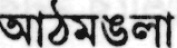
আঠমঙলা
